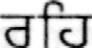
ਰਹਿ
